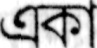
একা
